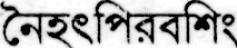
নৈহৎপিরবশিং
